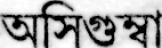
অসিগুম্বা
